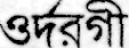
ওর্দরগী
